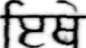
ਇਥੇ
